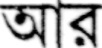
আর
